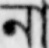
না
